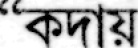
“কদায়
